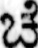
ಚೆ
